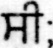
ਸੀ;
